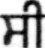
ਸੀ
